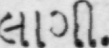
લાગી.
